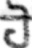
ਹੋ
